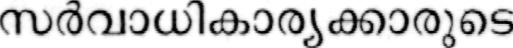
സര്‍വാധികാര്യക്കാരുടെ
